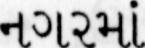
નગરમાં
